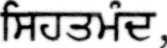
ਸਿਹਤਮੰਦ,
